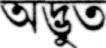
অদ্ভুত
